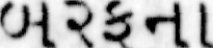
બરફના
